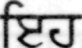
ਇਹ
